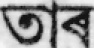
তাৰ
